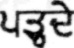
ਪੜ੍ਹਦੇ
